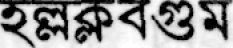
হল্লক্লবগুম
